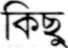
কিছু
